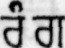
ਰੰਗ
